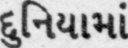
દુનિયામાં
